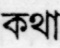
কথা
